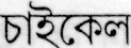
চাইকেল
